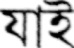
যাই
